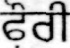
ਫ਼ੌਰੀ
